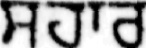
ਸਹਾਰ
